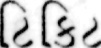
ટિકિટ
